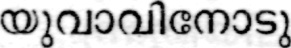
യുവാവിനോടു
